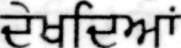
ਦੇਖਦਿਆਂ
